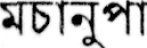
মচানুপা
